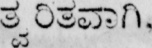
ತ್ವರಿತವಾಗಿ,
